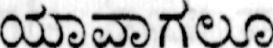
ಯಾವಾಗಲೂ
